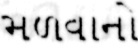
મળવાનો
